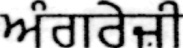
ਅੰਗਰੇਜ਼ੀ
